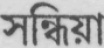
সন্ধিয়া
